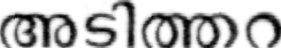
അടിത്തറ
